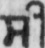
ਸੀ
